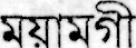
ময়ামগী
